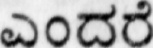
ಎಂದರೆ
